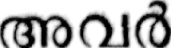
അവര്‍
